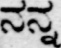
ನನ್ನ
